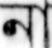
না
